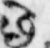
છે.
